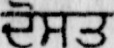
ਦੋਸਤ
